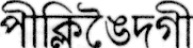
পীক্লিঙৈদগী
